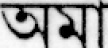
অমা
